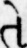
તે
